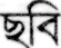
ছবি
